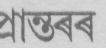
প্ৰান্তৰৰ
